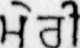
ਮੇਰੀ
